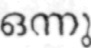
ഒന്നു
